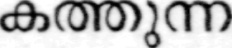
കത്തുന്ന
